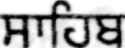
ਸਾਹਿਬ
